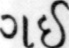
ગઈ
